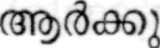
ആര്‍ക്കു
